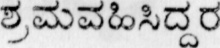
ಶ್ರಮವಹಿಸಿದ್ದರ
